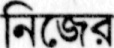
নিজের
